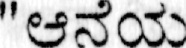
“ಆನೆಯ
